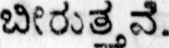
ಬೀರುತ್ತವೆ.
